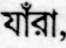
যাঁরা,
